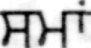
ਸਮਾਂ
